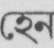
হেন
